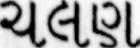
ચલણ
